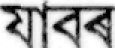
যাবৰ
